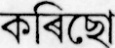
কৰিছো
